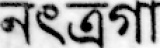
নৎত্রগা
